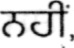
ਨਹੀਂ,
